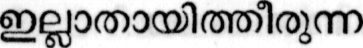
ഇല്ലാതായിത്തീരുന്ന
